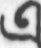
এ
